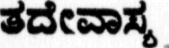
ತದೇವಾಸ್ಯ
